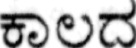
ಕಾಲದ
